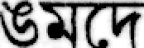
ঙমদে
